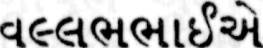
વલ્લભભાઈએ
